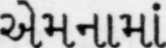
એમનામાં
